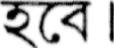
হবে।
